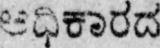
ಅಧಿಕಾರದ
